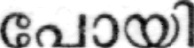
പോയി
